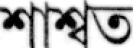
শাশ্বত
